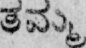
ತಮ್ಮ
